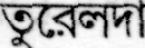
তুরেলদা
